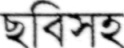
ছবিসহ
